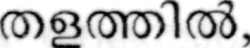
തളത്തില്‍,
